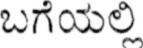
ಬಗೆಯಲ್ಲಿ
